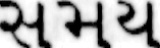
સમય
